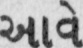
આવે
